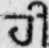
ਹੀ
